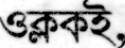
ওক্লকই,
